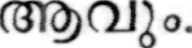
ആവും.
